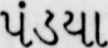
પંડયા
